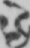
છે.
